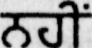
ਨਹੀਂ
